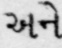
અને
